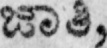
ಜಾತಿ,
